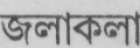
জলাকলা
